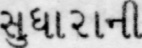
સુધારાની
